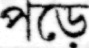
পড়ে
